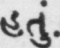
હતું.
